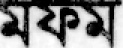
মফম
